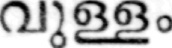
വുള്ളം
